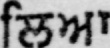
ਲਿਆ
